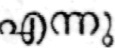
എന്നു
